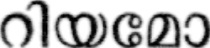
റിയമോ
